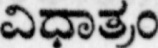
ವಿಧಾತ್ರಂ
